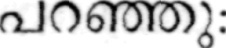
പറഞ്ഞു:
